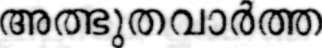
അത്ഭുതവാര്‍ത്ത
